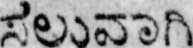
ಸಲುವಾಗಿ
